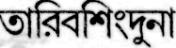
তারিবশিংদুনা
